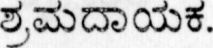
ಶ್ರಮದಾಯಕ.
